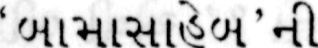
'બામાસાહેબ'ની
